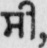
ਸੀ,
